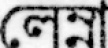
লেম্না
